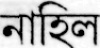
নাহিল
